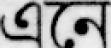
এনে
